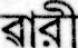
ৱারী
